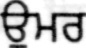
ਉਮਰ
